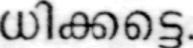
ധിക്കട്ടെ.
